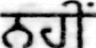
ਨਹੀਂ
